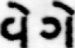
વેગે
